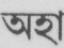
অহা
